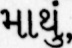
માથું,
